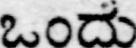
ಒಂದು
